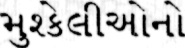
મુશ્કેલીઓનો
